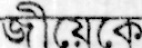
জীয়েকে
